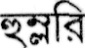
হুম্লরি
